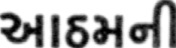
આઠમની
